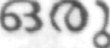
ഒരു
